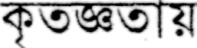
কৃতজ্ঞতায়
